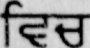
ਵਿਚ
